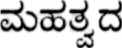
ಮಹತ್ವದ
